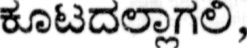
ಕೂಟದಲ್ಲಾಗಲಿ,
